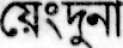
য়েংদুনা
